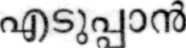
എടുപ്പാന്‍
